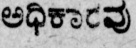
ಅಧಿಕಾರವು
